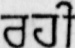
ਰਹੀ
